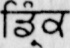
ਡ੍ਰਿੰਕ
